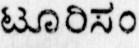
ಟೂರಿಸಂ
